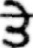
ਤੇ
